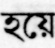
হয়ে
